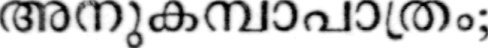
അനുകമ്പാപാത്രം;
